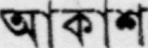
আকাশ
